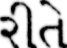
રીતે
